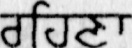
ਰਹਿਣਾ
